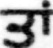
ਤਾਂ
